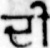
ਦੀ
